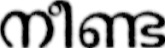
നീണ്ട
